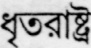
ধৃতরাষ্ট্র
